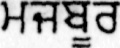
ਮਜਬੂਰ
